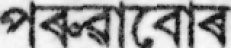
পৰুৱাবোৰ
